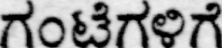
ಗಂಟೆಗಳಿಗೆ
